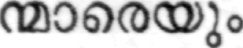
ന്മാരെയും
